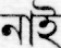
নাই
